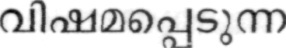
വിഷമപ്പെടുന്ന
